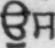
ਉਸ
